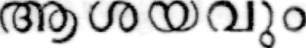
ആശയവും
